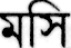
মসি
